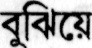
বুঝিয়ে
